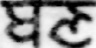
ਬਣ
